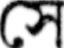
সে
